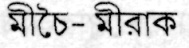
মীচৈ-মীরাক
